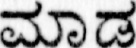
ಮಾಡ
